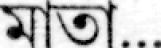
মাতা...
